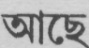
আছে
